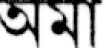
অমা
